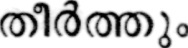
തീര്‍ത്തും
